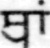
ਥਾਂ
